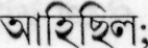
আহিছিল;
